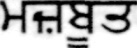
ਮਜ਼ਬੂਤ
